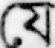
যে
